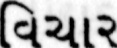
વિચાર
